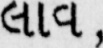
લાવ,
